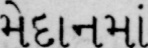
મેદાનમાં
